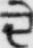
ਦੇ
